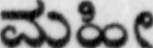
ಮಹೀ
